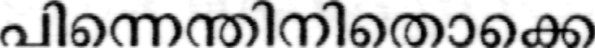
പിന്നെന്തിനിതൊക്കെ
